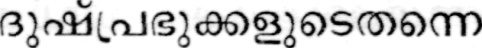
ദുഷ്പ്രഭുക്കളുടെതന്നെ
